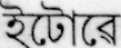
ইটোৱে
